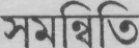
সমন্বিতি
